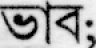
ভাব;
